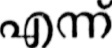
എന്ന്
